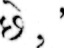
છે,'
